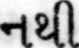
નથી
